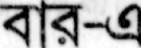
বার-এ
